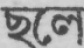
ছলে
